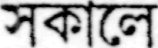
সকালে
